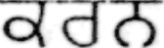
ਕਰਨ
